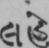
લહે
